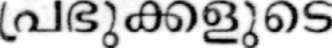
പ്രഭുക്കളുടെ
